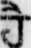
ਹੈ
